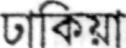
ঢাকিয়া
